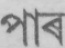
পাৰ
